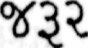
જરૂર
